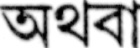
অথবা
